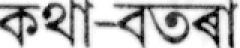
কথা-বতৰা
